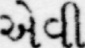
એવી
